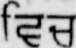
ਵਿਚ
